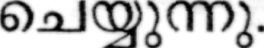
ചെയ്യുന്നു.
